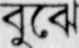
বুঝে
